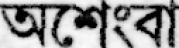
অশেংবা
